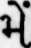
મેં
